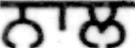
ਨਾਲ
